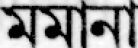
মমানা
